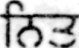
ਨਿਤ
